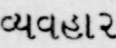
વ્યવહાર
